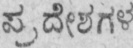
ಪ್ರದೇಶಗಳ
